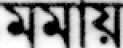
মমায়
